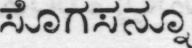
ಸೊಗಸನ್ನೂ
